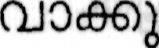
വാക്കു
